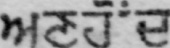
ਅਣਹੋਂਦ
